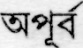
অপূর্ব
